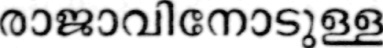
രാജാവിനോടുള്ള
